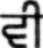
ਵੀ
